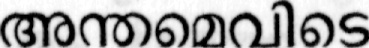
അന്തമെവിടെ
